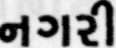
નગરી
